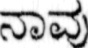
ನಾವು
